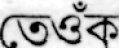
তেওঁক
